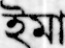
ইমা
